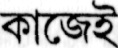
কাজেই
